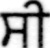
ਸੀ
